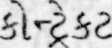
કોન્ટ્રેકટ
